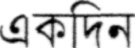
একদিন
